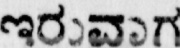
ಇರುವಾಗ
